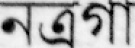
নত্রগা
